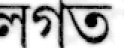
লগত
